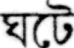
ঘটে
